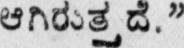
ಆಗಿರುತ್ತದೆ.”
